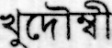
খুদৌম্বী
